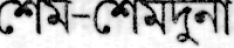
শেম-শেমদুনা
